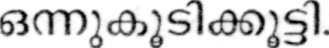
ഒന്നുകൂടിക്കൂട്ടി.
